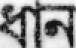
ধান
